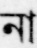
না
